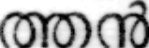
ത്തന്‍
